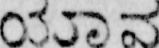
ಯಾವ
